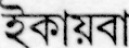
ইকায়বা
